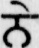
ਨੇ
